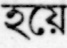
হয়ে
